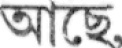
আছে,
